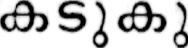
കടുകു
